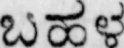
ಬಹಳ
